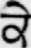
ਕੇ
